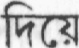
দিয়ে
